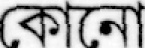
কোনো
